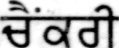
ਚੈਂਕਰੀ
